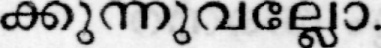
ക്കുന്നുവല്ലോ.
